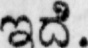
ಇದೆ.
